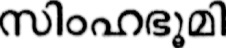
സിംഹഭൂമി
